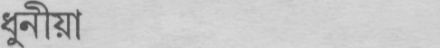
ধুনীয়া
